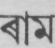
ৰাম
